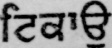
ਟਿਕਾਉ
